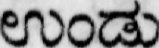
ಉಂಡು
